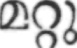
മറ്റു
